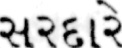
સરદારે
